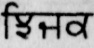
ਝਿਜਕ
